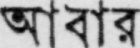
আবার
